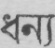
ধন্য
